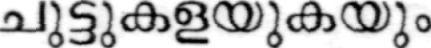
ചുട്ടുകളയുകയും
